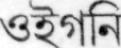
ওইগনি
